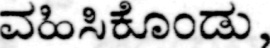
ವಹಿಸಿಕೊಂಡು,
